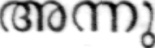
അന്നു
